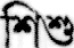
শিশু
